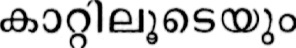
കാറ്റിലൂടെയും
